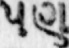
પણ
